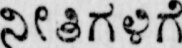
ನೀತಿಗಳಿಗೆ
